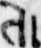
તો
